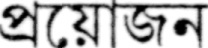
প্রয়োজন
